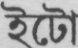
ইটো
